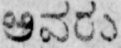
ಅವರು
